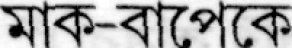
মাক-বাপেকে
